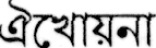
ঐখোয়না
